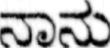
ನಾನು
